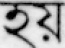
হয়
